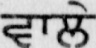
ਵਾਲੇ
